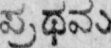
ಪ್ರಥಮ
